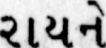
રાયને
